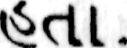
હતા.
